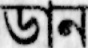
ডান
